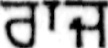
ਰਾਜ
